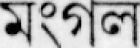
মংগল
